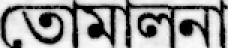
তোমালনা
